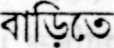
বাড়িতে
